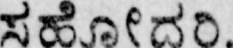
ಸಹೋದರಿ.
